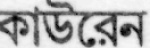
কাউরেন
